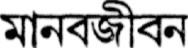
মানবজীবন
